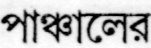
পাঞ্চালের
